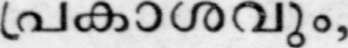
പ്രകാശവും,
